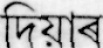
দিয়াৰ
